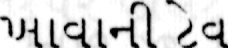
ખાવાનીટેવ
